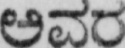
ಅವರ
